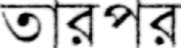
তারপর
